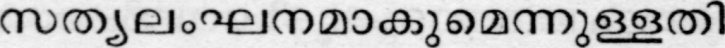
സത്യലംഘനമാകുമെന്നുള്ളതി
